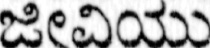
ಜೀವಿಯು
